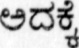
ಅದಕ್ಕೆ
